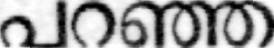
പറഞ്ഞ
